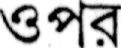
ওপর
